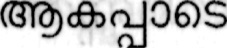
ആകപ്പാടെ
